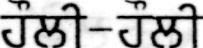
ਹੌਲੀ-ਹੌਲੀ
